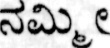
ನಮ್ಮೀ
